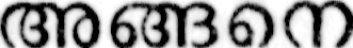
അങ്ങനെ
